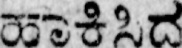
ಹಾಕಿಸಿದ
